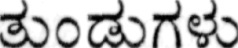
ತುಂಡುಗಳು
